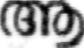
ആ
